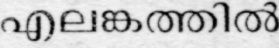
എലങ്കത്തില്‍
